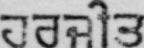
ਹਰਜੀਤ
